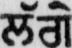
ਲੱਗੇ
